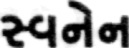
સ્વનેન
